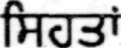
ਸਿਹਤਾਂ
